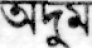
অদুম
